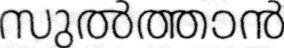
സുല്‍ത്താന്‍
